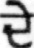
ਦੇ
